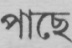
পাছে
